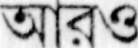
আরও
